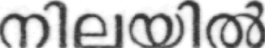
നിലയില്‍
